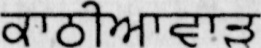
ਕਾਠੀਆਵਾੜ
